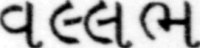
વલ્લભ
